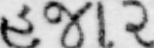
હજાર
